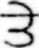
ਤੇ
